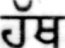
ਹੱਥ
